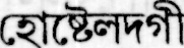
হোষ্টেলদগী
